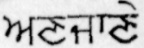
ਅਣਜਾਣੇ
